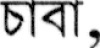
চাবা,
